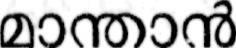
മാന്താന്‍
